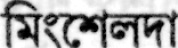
মিংশেলদা
